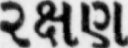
રક્ષણ
